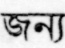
জন্য
